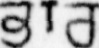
ਭਾਰ
